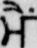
ਮੈਂ
